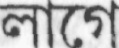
লাগে
